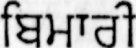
ਬਿਮਾਰੀ
